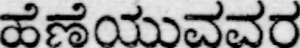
ಹೆಣೆಯುವವರ
